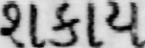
શકાય
